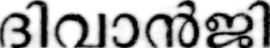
ദിവാന്‍ജി
